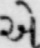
એ
